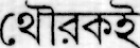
থৌরকই
